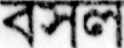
বসল
